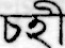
চহী
